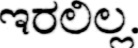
ಇರಲಿಲ್ಲ.
